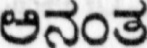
ಅನಂತ
